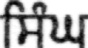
ਸਿੰਘ
